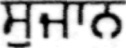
ਸੁਜਾਨ
